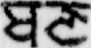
ਬਣ
